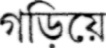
গড়িয়ে
